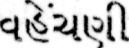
વહેંચણી
